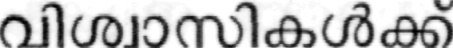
വിശ്വാസികള്‍ക്ക്
